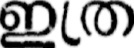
ഇത്ര
